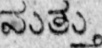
ಮತ್ತು
